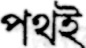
পথই
